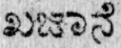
ಖಜಾನೆ
